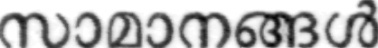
സാമാനങ്ങള്‍
